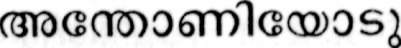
അന്തോണിയോടു
